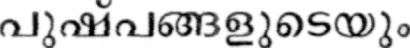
പുഷ്പങ്ങളുടെയും
